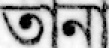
তানা
